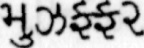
મુઝફ્ફર
